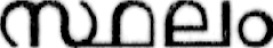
സ്ഥലം
